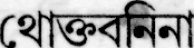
থোক্তবনিনা
